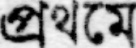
প্রথমে
